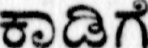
ಕಾಡಿಗೆ
